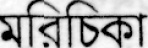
মরিচিকা
